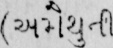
(અમૈથુની
